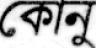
কোনু
